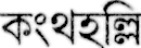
কংথহল্লি
